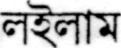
লইলাম
